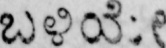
ಬಳಿಯೇ
